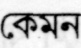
কেমন
